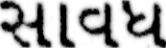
સાવધ
